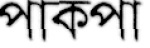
পাকপা
